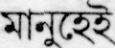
মানুহেই
